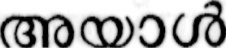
അയാള്‍
